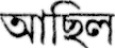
আছিল
